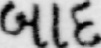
બાદ
